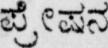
ಪ್ರೇಷನ
